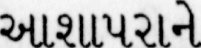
આશાપરાને
